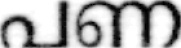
പണ
